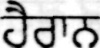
ਹੈਰਾਨ
